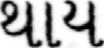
થાય
